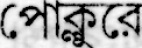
পোক্লুরে
